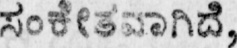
ಸಂಕೇತವಾಗಿದೆ,
